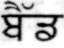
ਬੈੱਡ
